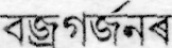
বজ্ৰগর্জনৰ
